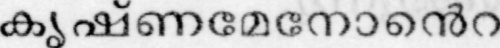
കൃഷ്ണമേനോന്റെ
